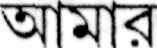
আমার
